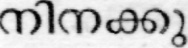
നിനക്കു
